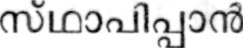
സ്ഥാപിപ്പാന്‍
